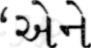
'એને
